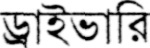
ড্রাইভারি
